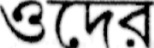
ওদের
